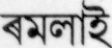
ৰমলাই
